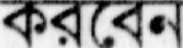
করবেন
